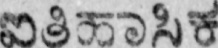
ಐತಿಹಾಸಿಕ
